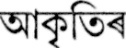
আকৃতিৰ
